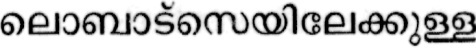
ലൊബാട്സെയിലേക്കുള്ള
